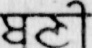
ਬਣੀ
